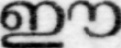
ഈ
